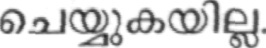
ചെയ്യുകയില്ല.
